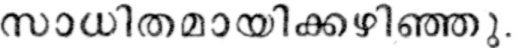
സാധിതമായിക്കഴിഞ്ഞു.
